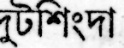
দুটশিংদা
